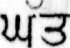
ਘੱਤ
